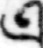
এ
